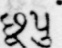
છૂપું
